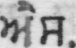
ਐਸ.
